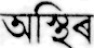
অস্থিৰ
